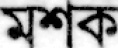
মশক
